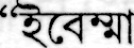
“ইবেম্মা
